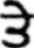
ਤੇ
